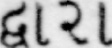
દ્વારા
